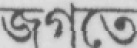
জগতে
